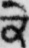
ਕੇ
